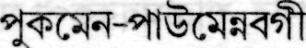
পুকমেন-পাউমেন্নবগী
